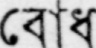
বোধ
